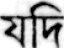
যদি
